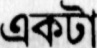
একটা
